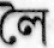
লৈ
